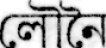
লৌনৈ
